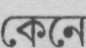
কেনে
